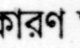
কারণ
